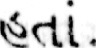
હતાં.
